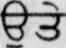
ਉਤੇ
